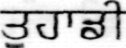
ਤੁਹਾਡੀ
